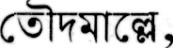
তৌদমাল্লে,
